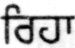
ਰਿਹਾ
